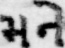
મને
